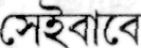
সেইবাবে
